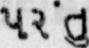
,પરંતુ
